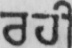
ਰਹੀ
